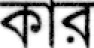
কার
